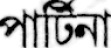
পার্টিনা
